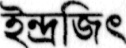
ইন্দ্রজিৎ
